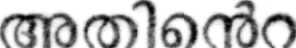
അതിന്റെ
